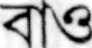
বাও
